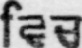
ਵਿਚ
